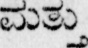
ಮತ್ತು
